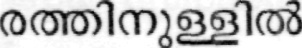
രത്തിനുള്ളില്‍
